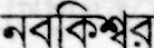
নবকিশ্বর
